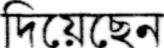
দিয়েছেন
